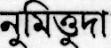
নুমিত্তুদা
